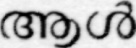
ആള്‍
